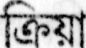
ক্রিয়া
